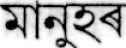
মানুহৰ
